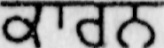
ਕਾਰਨ
